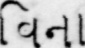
વિના
